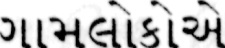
ગામલોકોએ
